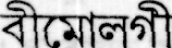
বীমোলগী
